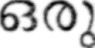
ഒരു
